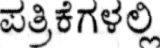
ಪತ್ರಿಕೆಗಳಲ್ಲಿ
